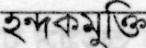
হন্দকমুক্তি
